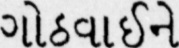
ગોઠવાઈને
